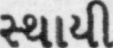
સ્થાયી
